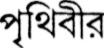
পৃথিবীর
